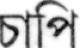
চাপি
